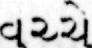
વચ્ચે
